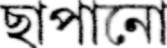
ছাপানো
